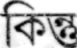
কিন্তু
